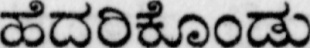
ಹೆದರಿಕೊಂಡು
